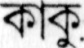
কাকু
